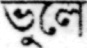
ভুলে
